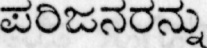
ಪರಿಜನರನ್ನು
